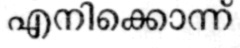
എനിക്കൊന്ന്
